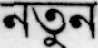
নতুন
